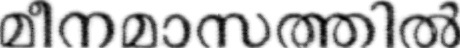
മീനമാസത്തില്‍
